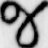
જ
